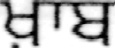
ਖ਼ਾਬ
